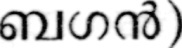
ബഗന്‍)
